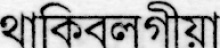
থাকিবলগীয়া
